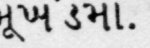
ભૂખંડમાં.
